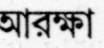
আরক্ষা
